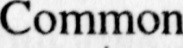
Common
